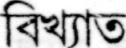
বিখ্যাত
